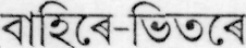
বাহিৰে-ভিতৰে
